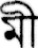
মী
